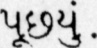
પૂછયું.
